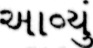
આવ્યું
